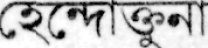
হেন্দোক্তুনা
